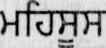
ਮਹਿਸੂਸ
